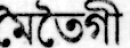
মৈতৈগী
